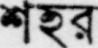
শহর
